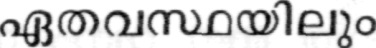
ഏതവസ്ഥയിലും
